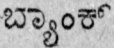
ಬ್ಯಾಂಕ್
